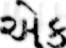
એક
